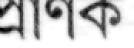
প্ৰাণক
